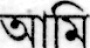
আমি
